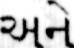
અને
